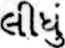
લીધું
